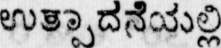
ಉತ್ಪಾದನೆಯಲ್ಲಿ
